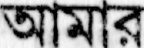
আমার
